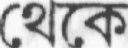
থেকে
